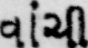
વાંચી
